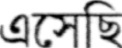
এসেছি
